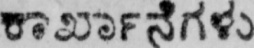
ಕಾರ್ಖಾನೆಗಳು
